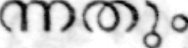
ന്നതും
